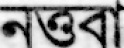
নত্তবা
